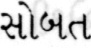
સોબત
